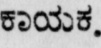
ಕಾಯಕ.
